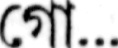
গো...
